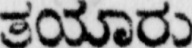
ತಯಾರು
